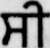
ਸੀ
